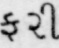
ફરી
